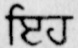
ਇਹ
